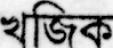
খজিক
